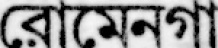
রোমেনগা
